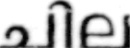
ചില
